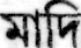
মাদি
